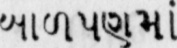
બાળપણમાં
